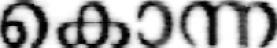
കൊന്ന
